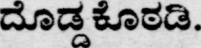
ದೊಡ್ಡಕೊಠಡಿ.
